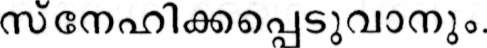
സ്നേഹിക്കപ്പെടുവാനും.
